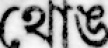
থোঙ
